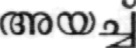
അയച്ച്
